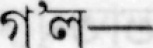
গ'ল-
